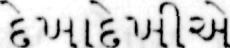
દેખાદેખીએ
